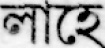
লাহে
